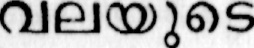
വലയുടെ
